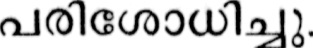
പരിശോധിച്ചു.
